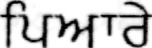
ਪਿਆਰੇ
